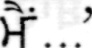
ਮੈਂ...'
